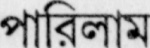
পারিলাম
